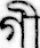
গী
